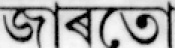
জাৰতো
